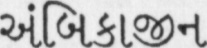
અંબિકાજીન
